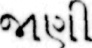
જાણી
